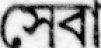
সেবা
